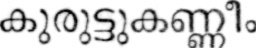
കുരുട്ടുകണ്ണീം
